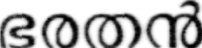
ഭരതന്‍
